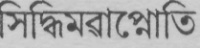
সিদ্ধিমৱাপ্নোতি
